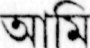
আমি
